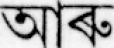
আৰু
